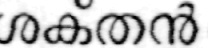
ശക്തന്‍
